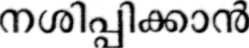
നശിപ്പിക്കാന്‍
